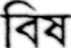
বিষ
